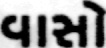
વાસો
